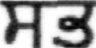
ਸਭ
